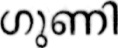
ഗുണി
